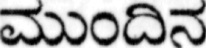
ಮುಂದಿನ
